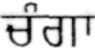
ਚੰਗਾ
